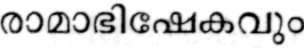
രാമാഭിഷേകവും
